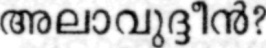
അലാവുദ്ദീന്‍?
